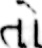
તો
